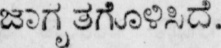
ಜಾಗೃತಗೊಳಿಸಿದೆ.
